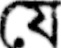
যে
